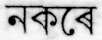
নকৰে
